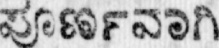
ಪೂರ್ಣವಾಗಿ
